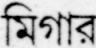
মিগার
